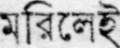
মরিলেই
